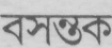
বসন্তক
